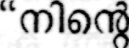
“നിന്റെ
